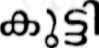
കുട്ടി
